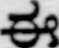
ಈ
